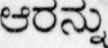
ಆರನ್ನು
